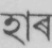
হাৰ
